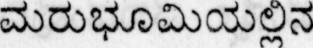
ಮರುಭೂಮಿಯಲ್ಲಿನ
